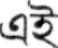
এই
